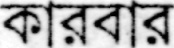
কারবার
